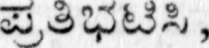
ಪ್ರತಿಭಟಿಸಿ,
